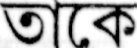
তাকে
